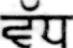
ਵੱਧ
